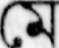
মে
